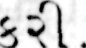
કરી.
